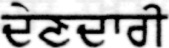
ਦੇਣਦਾਰੀ
